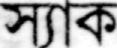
স্যাক
